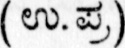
(ಉ.ಪ್ರ)
